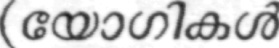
(യോഗികള്‍
